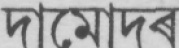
দামোদৰ
